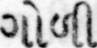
ગોળી
